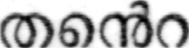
തന്റെ
